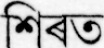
শিৰত
